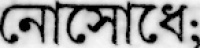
নোসোধে;
